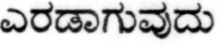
ಎರಡಾಗುವುದು
